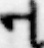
ન
